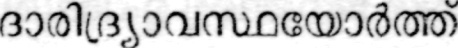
ദാരിദ്ര്യാവസ്ഥയോര്‍ത്ത്
